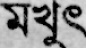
মখুৎ
